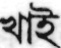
খাই
